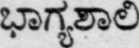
ಭಾಗ್ಯಶಾಲಿ
